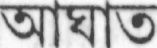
আঘাত
